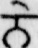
ਨੇ
